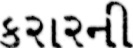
કરારની
